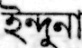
ইন্দুনা
